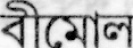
বীমোল
